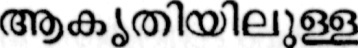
ആകൃതിയിലുള്ള
